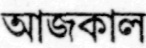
আজকাল
